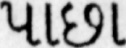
પાછા
